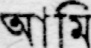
আমি
